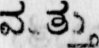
ಮತ್ತು
